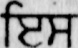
ਇਸ
